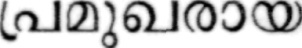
പ്രമുഖരായ
